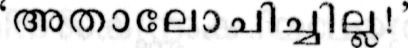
‘അതാലോചിച്ചില്ല!’
